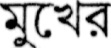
মুখের
